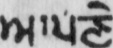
ਆਪਣੇ
